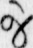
જે
